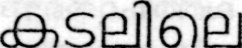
കടലിലെ
